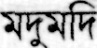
মদুমদি
